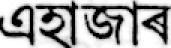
এহাজাৰ
